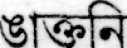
ঙাক্তনি
